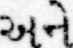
અને
